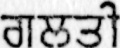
ਗਲਤੀ
